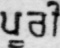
ਪੂਰੀ
